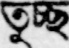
তুচ্ছ
